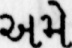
અમે
